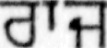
ਰਾਜ
